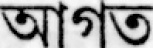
আগত
